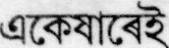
একেষাৰেই
